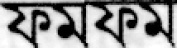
ফমফম
